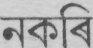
নকৰি
